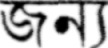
জন্য
